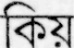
কিয়
